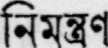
নিমন্ত্রণ
